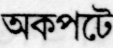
অকপটে
